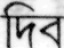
দিব
